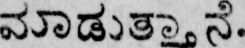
ಮಾಡುತ್ತಾನೆ.
